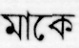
মাকে
